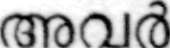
അവര്‍
